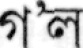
গ'ল
